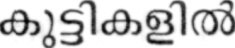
കുട്ടികളില്‍
